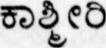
ಕಾಶ್ಮೀರಿ
